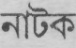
নাটক
